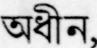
অধীন,
